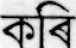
কৰি
